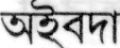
অইবদা
